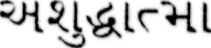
અશુદ્ધાત્મા
